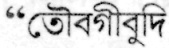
“তৌবগীবুদি
